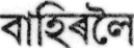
বাহিৰলৈ
